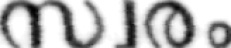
സ്വരം
